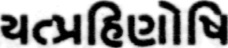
યત્પ્રહિણોષિ
